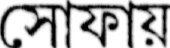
সোফায়
